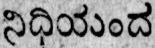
ನಿಧಿಯಿಂದ
